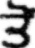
ਤੋਂ
